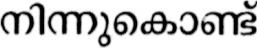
നിന്നുകൊണ്ട്
